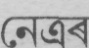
নেত্রৰ
